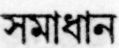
সমাধান
